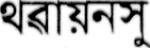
থৱায়নসু
